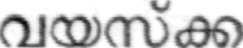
വയസ്ക്ക
